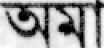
অমা
